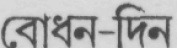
বোধন-দিন
